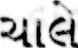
ચાલે
